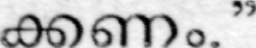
ക്കണം."
